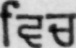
ਵਿਚ
